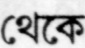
থেকে
